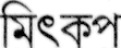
মিৎকপ
